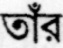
তাঁর
